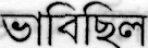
ভাবিছিল
